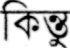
কিন্তু
